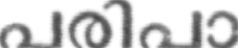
പരിപാ
